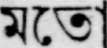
মতো
